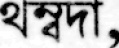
থম্বদা,
